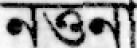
নত্তনা
